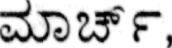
ಮಾರ್ಚ್,
